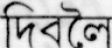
দিবলৈ
